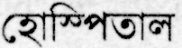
হোস্পিতাল
